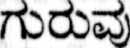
ಗುರುವು
